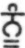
ਨੂੰ
